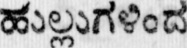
ಹುಲ್ಲುಗಳಿಂದ
